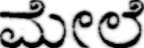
ಮೇಲೆ
